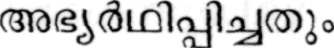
അഭ്യര്‍ഥിപ്പിച്ചതും
